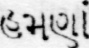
હમણાં
